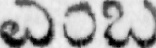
ಎಂಬ
